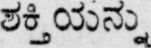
ಶಕ್ತಿಯನ್ನು
